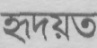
হৃদয়ত
